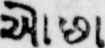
ઓછા
